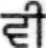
ਵੀ
